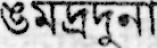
ঙমদ্রদুনা
